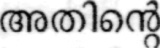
അതിന്റെ
